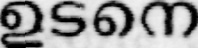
ഉടനെ
